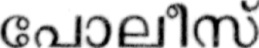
പോലീസ്
